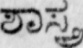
ಶಾಸ್ತ್ರ
